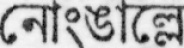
নোংঙাল্লে
